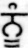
ਨੂੰ
